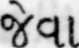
જેવા
